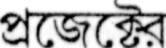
প্রজেক্টের
